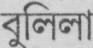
বুলিলা
